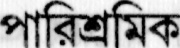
পারিশ্রমিক
